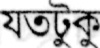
যতটুকু
